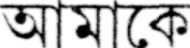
আমাকে
